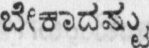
ಬೇಕಾದಷ್ಟು
